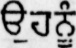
ਉਹਨੂੰ
